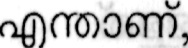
എന്താണ്,
